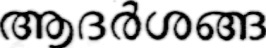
ആദര്‍ശങ്ങ
